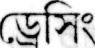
ড্রেসিং
